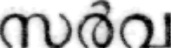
സര്‍വ
